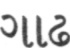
ગાઢ
